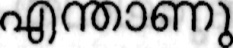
എന്താണു
